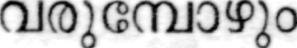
വരുമ്പോഴും
